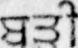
ਬੜੀ
